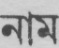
নাম
